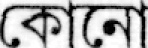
কোনো
